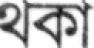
থকা
